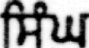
ਸਿੰਘ
